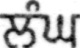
ਲੰਘ
